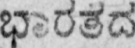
ಭಾರತದ
